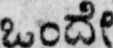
ಒಂದೇ
